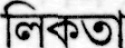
লিকতা
